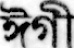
ঈগী
